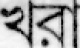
খরা
